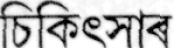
চিকিৎসাৰ
